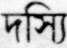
দস্যি
